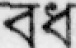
বধ
